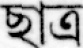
ছাত্র
